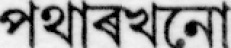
পথাৰখনো
